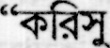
“করিসু
